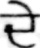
ਦੇ
